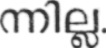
ന്നില്ല.
